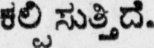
ಕಲ್ಪಿಸುತ್ತಿದೆ.
